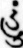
હું
